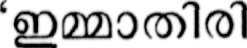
‘ഇമ്മാതിരി
